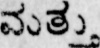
ಮತ್ತು
